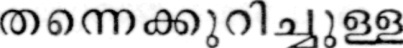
തന്നെക്കുറിച്ചുള്ള
